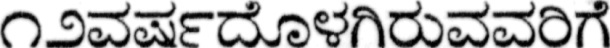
೧೨ವರ್ಷದೊಳಗಿರುವವರಿಗೆ
